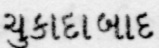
ચુકાદાબાદ
